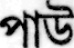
পাউ
